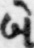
બે
